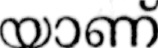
യാണ്
